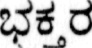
ಭಕ್ತರ
